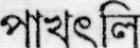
পাখৎলি
